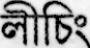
লীচিং
